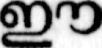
ഈ
